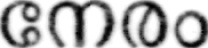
നേരം
